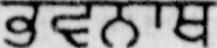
ਭਵਨਾਥ
